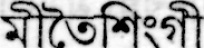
মীতৈশিংগী
